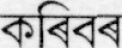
কৰিবৰ
